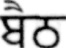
ਬੈਠ
